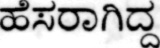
ಹೆಸರಾಗಿದ್ದ
